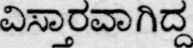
ವಿಸ್ತಾರವಾಗಿದ್ದ
